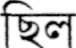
ছিল
